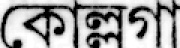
কোল্লগা
